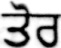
ਤੋਰ
